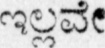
ಇಲ್ಲವೇ
